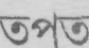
তপত
